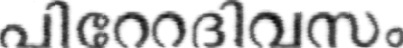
പിറ്റേദിവസം
